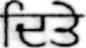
ਦਿਤੇ
